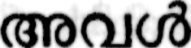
അവള്‍
